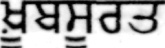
ਖ਼ੂਬਸੂਰਤ
